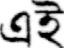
এই
